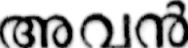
അവന്‍
